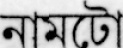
নামটো
